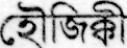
হৌজিক্কী
